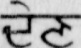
ਦੇਣ
